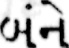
બંને
